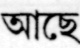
আছে
